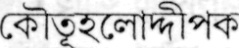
কৌতূহলোদ্দীপক
